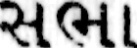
સભા
